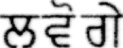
ਲਵੋਗੇ
